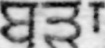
ਬੜਾ
